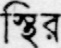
স্থির
